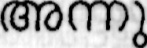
അന്നു
